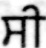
ਸੀ
